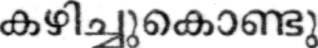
കഴിച്ചുകൊണ്ടു
